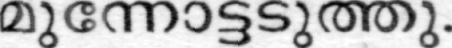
മുന്നോട്ടടുത്തു.
